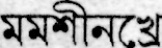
মমশীনখ্রে
